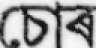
চোৰ
